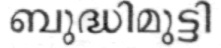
ബുദ്ധിമുട്ടി
